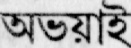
অভয়াই
